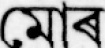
মোৰ
